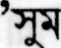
’সুম
